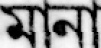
মানা
